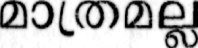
മാത്രമല്ല
